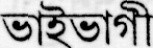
ভাইভাগী
